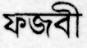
ফজবী
